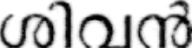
ശിവന്‍
